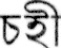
চহী
